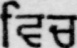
ਵਿਚ
